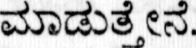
ಮಾಡುತ್ತೇನೆ.
